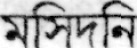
মসিদনি
